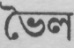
ভৈল
